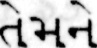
તેમને
